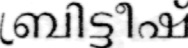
ബ്രിട്ടീഷ്
